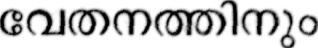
വേതനത്തിനും
